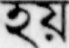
হয়
